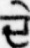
ਦੇ
